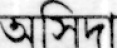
অসিদা
